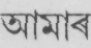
আমাৰ
